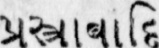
પ્રસ્ત્રાવાદિ
